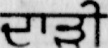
ਦਾੜੀ
